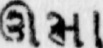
ઊભા
